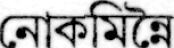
নোকমিন্নৈ
